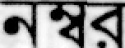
নম্বর
